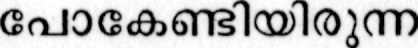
പോകേണ്ടിയിരുന്ന
